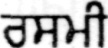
ਰਸਮੀ
